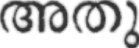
അതു
